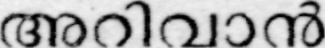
അറിവാന്‍
